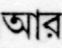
আর
